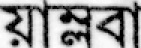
য়াম্লবা
